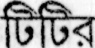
টিটির
